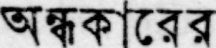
অন্ধকারের
